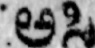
ಅಸಿ
